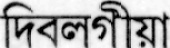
দিবলগীয়া
